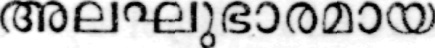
അലഘുഭാരമായ
